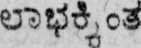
ಲಾಭಕ್ಕಿಂತ
